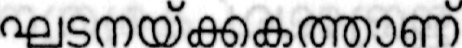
ഘടനയ്ക്കകത്താണ്
